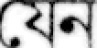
যেন
